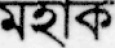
মহাক
